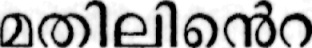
മതിലിന്റെ
